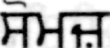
ਸੋਮਜ਼
